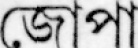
জোপা
